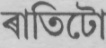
ৰাতিটো
